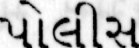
પોલીસ
